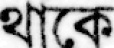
থাকে
